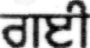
ਗਈ
